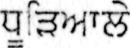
ਧੂੜਿਆਲੇ
